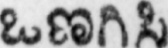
ಒಣಗಿಸಿ
